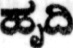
ಹೃದಿ
